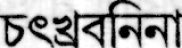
চৎখ্রবনিনা
